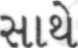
સાથે
